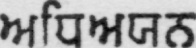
ਅਧਿਅਯਨ
